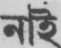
নাই
